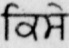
ਕਿਸੇ
